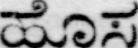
ಹೊಸ
